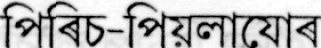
পিৰিচ-পিয়লাযোৰ
